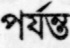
পর্যন্ত
